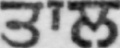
ਤਾਲ
